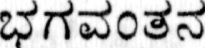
ಭಗವಂತನ
